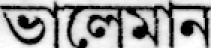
ভালেমান
